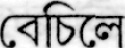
বেচিলে
